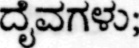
ದೈವಗಳು;
